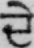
ਦੇ
